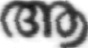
ആ
